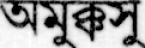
অমুক্কা
